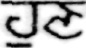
ਹੁਣ
